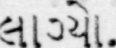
લાગ્યો.
